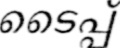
ടൈപ്പ്
